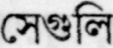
সেগুলি
